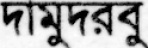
দামুদরবু
